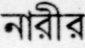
নারীর
